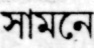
সামনে
